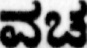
ವಚ
